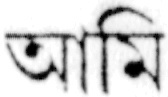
আমি
